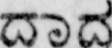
ದಾದ
